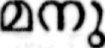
മനു
